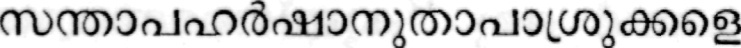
സന്താപഹര്‍ഷാനുതാപാശ്രുക്കളെ
